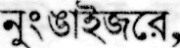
নুংঙাইজরে,
